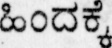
ಹಿಂದಕ್ಕೆ
